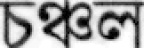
চঞ্চল
